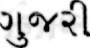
ગુજરી
